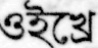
ওইখ্রে
